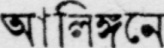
আলিঙ্গনে
